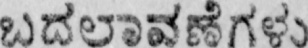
ಬದಲಾವಣೆಗಳು
